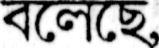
বলেছে,
